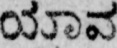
ಯಾವ
